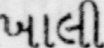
ખાલી
